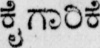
ಕೈಗಾರಿಕೆ
